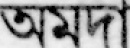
অমদা
